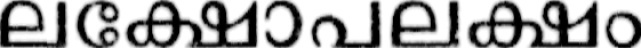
ലക്ഷോപലക്ഷം
